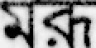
মরূ
